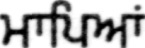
ਮਾਪਿਆਂ
